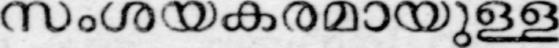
സംശയകരമായുള്ള
